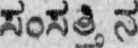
ಸಂಸತ್ತಿನ
